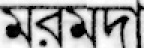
মরমদা
